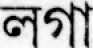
লগা
